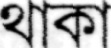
থাকা
